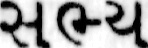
સભ્ય
